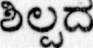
ಶಿಲ್ಪದ
